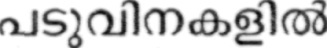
പടുവിനകളില്‍
